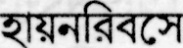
হায়নরিবসে
